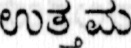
ಉತ್ತಮ
